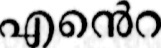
എന്റെ
